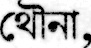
থৌনা,
